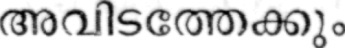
അവിടത്തേക്കും
